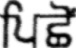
ਪਿਛੋਂ
